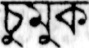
চুমুক
